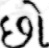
છો
